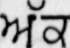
ਅੱਕ
